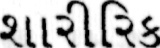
શારીરિક
